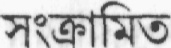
সংক্রামিত
